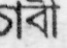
চাবী
